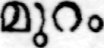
മുറം
